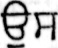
ਉਸ
